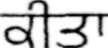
ਕੀਤਾ
